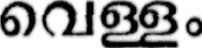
വെള്ളം
